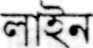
লাইন
